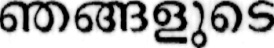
ഞങ്ങളുടെ
